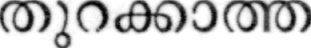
തുറക്കാത്ത
